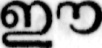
ഈ
